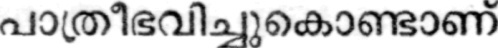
പാത്രീഭവിച്ചുകൊണ്ടാണ്
